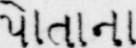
પોતાના
